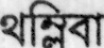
থম্লিবা
